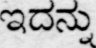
ಇದನ್ನು
